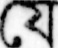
যে
